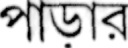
পাড়ার
